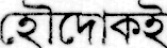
হৌদোকই
